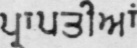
ਪ੍ਰਾਪਤੀਆਂ
